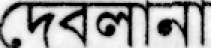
দেবলানা
